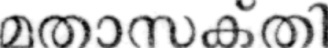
മതാസക്തി
